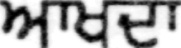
ਆਖਦਾ
